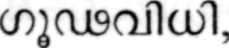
ഗൂഢവിധി,
